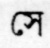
সে
